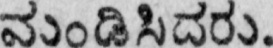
ಮಂಡಿಸಿದರು.
